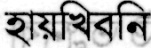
হায়খিবনি
